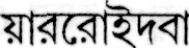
য়াররোইদবা
